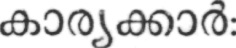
കാര്യക്കാര്‍:
